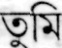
তুমি
